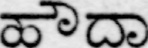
ಹೌದಾ
